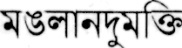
মঙলানদুমক্তি
